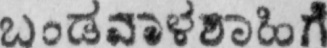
ಬಂಡವಾಳಶಾಹಿಗೆ
